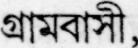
গ্রামবাসী,
